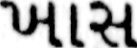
ખાસ
